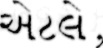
એટલે,
